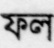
ফল
